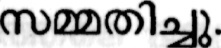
സമ്മതിച്ചു.
